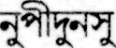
নুপীদুনসু
